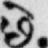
છે.
